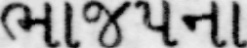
ભાજપના
